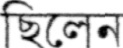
ছিলেন
